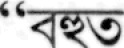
"বহুত
